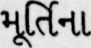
મૂર્તિના
